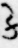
કે
